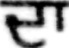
ਦਾ
